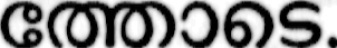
ത്തോടെ.
